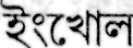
ইংখোল
